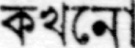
কখনো
